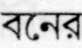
বনের
